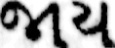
જાય
